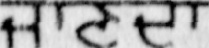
ਜਾਣਦਾ
